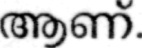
ആണ്.
